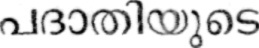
പദാതിയുടെ
